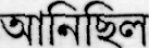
আনিছিল
